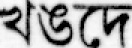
খঙদে
